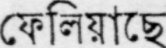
ফেলিয়াছে
